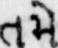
તમે
